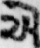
એ
